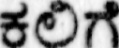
ಕಲಿಗೆ
